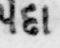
પેદા
